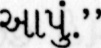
આપું."
